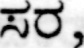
ಸರ,
